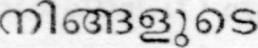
നിങ്ങളുടെ
